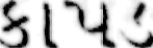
કાપડ
